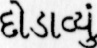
દોડાવ્યું
